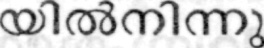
യില്‍നിന്നു
